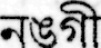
নঙগী
